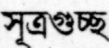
সূত্রগুচ্ছ
